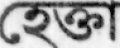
হেক্তা
